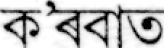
ক'ৰবাত
